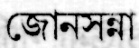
জোনসন্না
